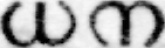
ധന
